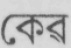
কেৱ
